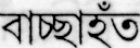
বাচ্ছাহঁত
